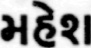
મહેશ
